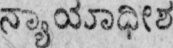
ನ್ಯಾಯಾಧೀಶ
